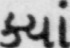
ક્યાં
